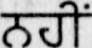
ਨਹੀਂ
